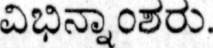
ವಿಭಿನ್ನಾಂಶರು.
